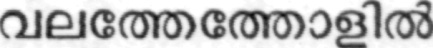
വലത്തേത്തോളില്‍
